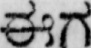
ಈಗ
